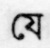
যে
